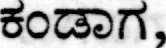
ಕಂಡಾಗ,
